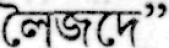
লৈজদে”
